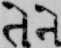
તેને
